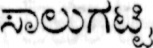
ಸಾಲುಗಟ್ಟಿ
